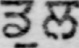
ਡੁਲ
